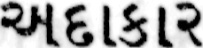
અદાકાર
